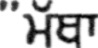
''ਮੱਥਾ
